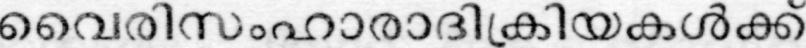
വൈരിസംഹാരാദിക്രിയകള്‍ക്ക്
